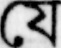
যে
